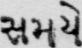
સમયે
